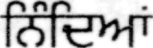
ਨਿੰਦਿਆਂ
